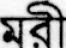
মরী
